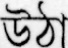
উঠা
